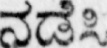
ನಡೆಸಿ
